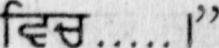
ਵਿਚ...।''
